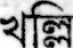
খল্লি
